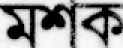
মশক
